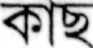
কাছ
